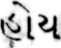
હોય
